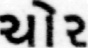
ચોર
